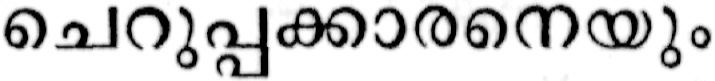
ചെറുപ്പക്കാരനെയും
